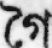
গৈ
